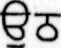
ਉਠ
